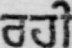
ਰਹੀ
